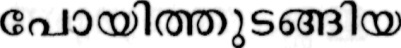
പോയിത്തുടങ്ങിയ
